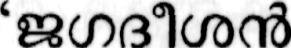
‘ജഗദീശന്‍
